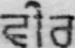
ਵੀਰ
